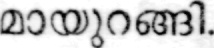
മായുറങ്ങി.
